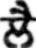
ਲੈ
